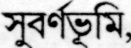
সুবর্ণভূমি,
